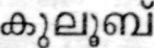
കുലൂബ്
